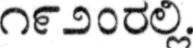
೧೯೨೦ರಲ್ಲಿ.
